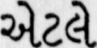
એટલે
